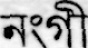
নংগী
